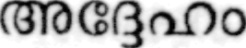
അദ്ദേഹം
